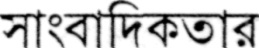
সাংবাদিকতার
